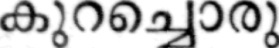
കുറച്ചൊരു
